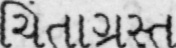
ચિંતાગ્રસ્ત
